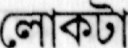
লোকটা
